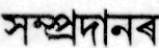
সম্প্রদানৰ
